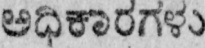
ಅಧಿಕಾರಗಳು
